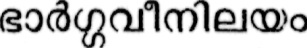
ഭാര്‍ഗ്ഗവീനിലയം
